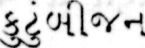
કુટુંબીજન
